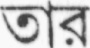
তার
